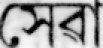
সেৱা
